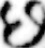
છ
